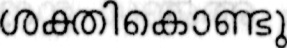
ശക്തികൊണ്ടു
